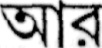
আর
